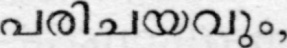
പരിചയവും,
